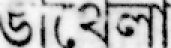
ঙাথেলা
